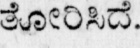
ತೋರಿಸಿದೆ.
